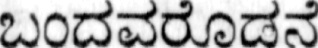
ಬಂದವರೊಡನೆ
